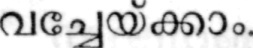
വച്ചേയ്ക്കാം.
